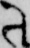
તે
